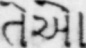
તેઓ
